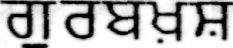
ਗੁਰਬਖ਼ਸ਼
